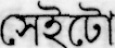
সেইটো
